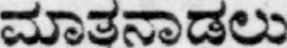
ಮಾತನಾಡಲು
